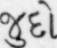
જુદો
